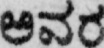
ಅವರ
